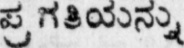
ಪ್ರಗತಿಯನ್ನು
